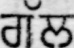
ਗੱਲ
